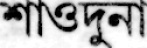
শাওদুনা
